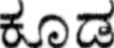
ಕೂಡ
